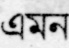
এমন
